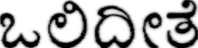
ಒಲಿದೀತೆ
